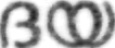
ദയ
